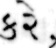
કરે,
